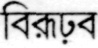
বিরূঢ়ব
